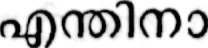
എന്തിനാ
